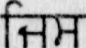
ਜਿਸ
